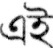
এই
